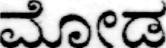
ಮೋಡ
